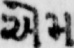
એમ
